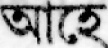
আহে
